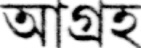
আগ্রহ
